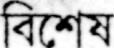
বিশেষ
